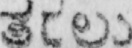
ತರಲು
